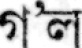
গ'ল
